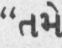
"તમે
